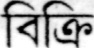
বিক্রি
